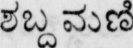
ಶಬ್ದಮಣಿ
